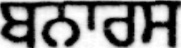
ਬਨਾਰਸ
